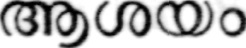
ആശയം
